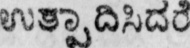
ಉತ್ಪಾದಿಸಿದರೆ
